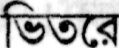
ভিতরে
